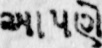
આપણે
